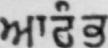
ਆਰੰਭ
